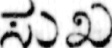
ಸುಖ
